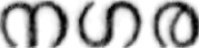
നഗര
